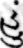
હું
